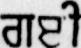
ਗਈ
